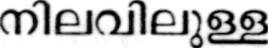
നിലവിലുള്ള
